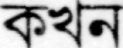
কখন
